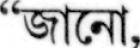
"জানো,
